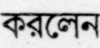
করলেন
